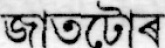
জাতটোৰ
